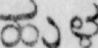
ಹುಳ
